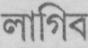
লাগিব
